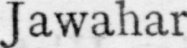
Jawahar
